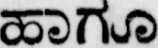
ಹಾಗೂ
